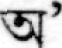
অ'
